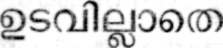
ഉടവില്ലാതെ
